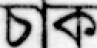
চাক
